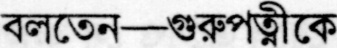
বলতেন–—গুরুপত্মীকে
